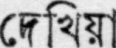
দেখিয়া
